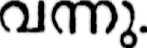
വന്നു.
